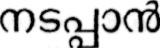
നടപ്പാന്‍
